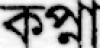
কপ্না
